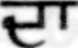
ਦਾ
